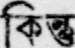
কিন্তু
